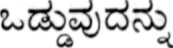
ಒಡ್ಡುವುದನ್ನು
